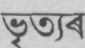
ভৃত্যৰ
